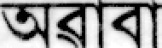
অৱাবা
